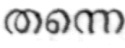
തന്നെ
